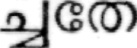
ച്ചതേ
